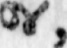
જ,
